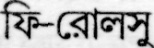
ফি-রোলসু
